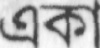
একা
